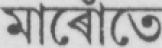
মাৰোঁতে
